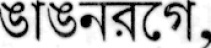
ঙাহনরগে,
